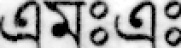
এমঃএঃ
